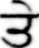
ਤੇ
